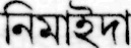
নিমাইদা
